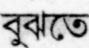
বুঝতে
